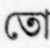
তো
